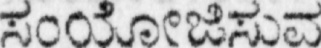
ಸಂಯೋಜಿಸುವ
